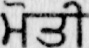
ਮੋਤੀ
